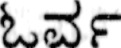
ಓರ್ವ
